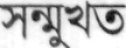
সন্মুখত
